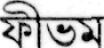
ফীভম
